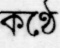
কণ্ঠে
